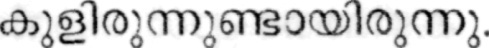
കുളിരുന്നുണ്ടായിരുന്നു.
